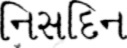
નિસદિન
